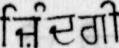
ਜ਼ਿੰਦਗੀ
